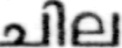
ചില
